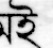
মই
